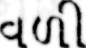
વળી
